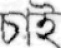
চাই
